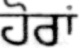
ਹੋਰਾਂ
